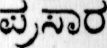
ಪ್ರಸಾರ
